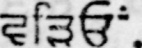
ਵੜਿਓਂ
